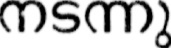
നടന്നു
